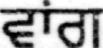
ਵਾਂਗ
